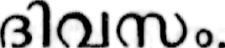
ദിവസം.
